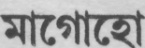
মাগোহো
